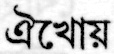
ঐখোয়
